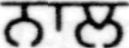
ਨਾਲ
